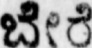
ಬೇರೆ
